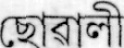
ছোৱালী
